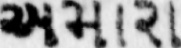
અમારા
